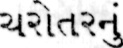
ચરોતરનું
